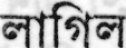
লাগিল
